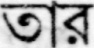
তার
